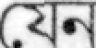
যেন
